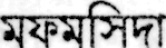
মফমসিদা
